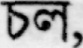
চল,
